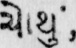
ચોથું,
